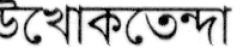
উখোকতেন্দা
